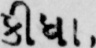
કીધા,
